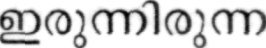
ഇരുന്നിരുന്ന
